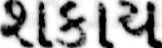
શકાય
